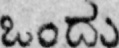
ಒಮ್ದು
